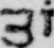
ਤਾਂ
